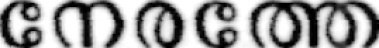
നേരത്തേ
